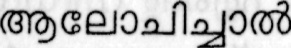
ആലോചിച്ചാല്‍
